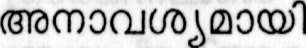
അനാവശ്യമായി
